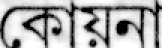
কোয়না
